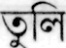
তুলি
